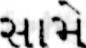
સામે
